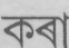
কৰা
